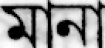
মানা
